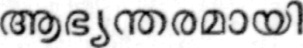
ആഭ്യന്തരമായി
